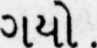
ગયો.
